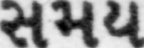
સમય
